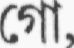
গো,
